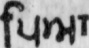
ਪਿਆ
